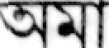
অমা
